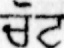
ਚੋਟ
